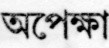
অপেক্ষা
